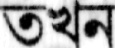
তখন
